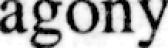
agony
